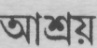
আশ্ৰয়
